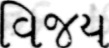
વિજય
